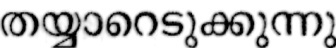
തയ്യാറെടുക്കുന്നു
